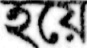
হয়ে
